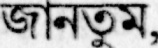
জানতুম,
